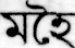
মহৈ
